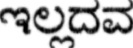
ಇಲ್ಲದವ
